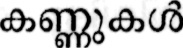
കണ്ണുകള്‍
